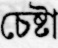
চেষ্টা
